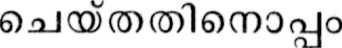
ചെയ്തതിനൊപ്പം
